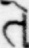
તે
